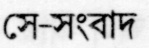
সে-সংবাদ
